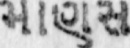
માણસ
